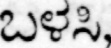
ಬಳಸಿ,
